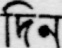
দিন
